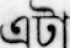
এটা
